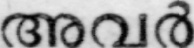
അവര്‍
